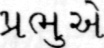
પ્રભુએ
